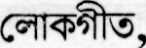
লোকগীত,
